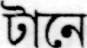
টানে
